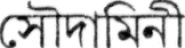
সৌদামিনী
